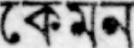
কেমন
